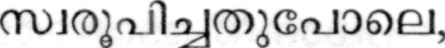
സ്വരൂപിച്ചതുപോലെ,
